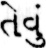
તેવું
